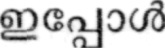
ഇപ്പോള്‍
